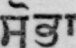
ਸੋਭਾ
